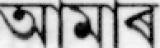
আমাৰ
